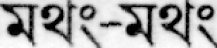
মথং-মথং
